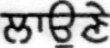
ਲਾਉਣੇ
